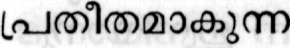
പ്രതീതമാകുന്ന
